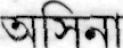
অসিনা
